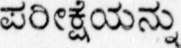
ಪರೀಕ್ಷೆಯನ್ನು
